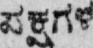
ಪಕ್ಷಗಳ
